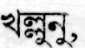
খল্লুনু,
